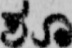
ಶೂ
